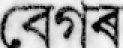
বেগৰ
